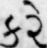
કરે
